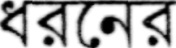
ধরনের
